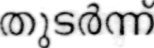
തുടര്‍ന്ന്
